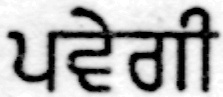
ਪਵੇਗੀ
